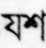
যশ
